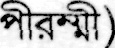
পীরম্মী)
